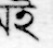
মই
